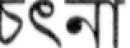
চৎনা
